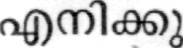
എനിക്കു
